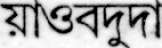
য়াওবদুদা
